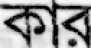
কার
